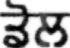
ਡੋਲ
